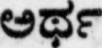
ಅರ್ಥ
